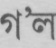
গ'ল
